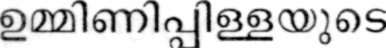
ഉമ്മിണിപ്പിള്ളയുടെ
